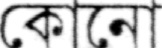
কোনো
